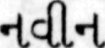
નવીન
